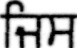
ਜਿਸ
